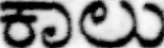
ಕಾಲು
